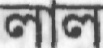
লাল
